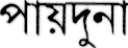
পায়দুনা
